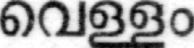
വെള്ളം
